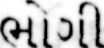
ભોગી
